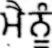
ਮੈਨੂੰ
